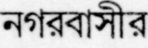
নগরবাসীর
